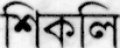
শিকলি
